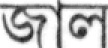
জাল
